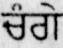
ਚੰਗੇ
